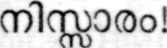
നിസ്സാരം!
